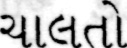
ચાલતો
